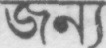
জন্য
